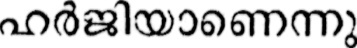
ഹര്‍ജിയാണെന്നു
